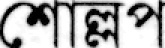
শোল্লপ
